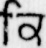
ਕਿ
